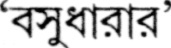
‘বসুধারার’
